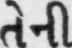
તેની
